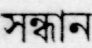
সন্ধান
